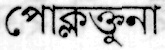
পোক্লক্তুনা
